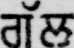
ਗੱਲ
